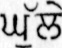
ਘੁੱਲੇ
